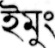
ইমুং
